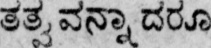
ತತ್ವವನ್ನಾದರೂ
